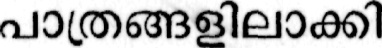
പാത്രങ്ങളിലാക്കി
